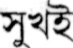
সুখই
